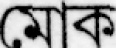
মোক
